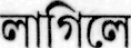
লাগিলে
